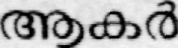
ആകര്‍
